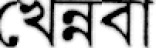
খেন্নবা
